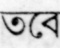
তবে
